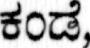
ಕಂಡೆ,
